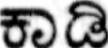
ಕಾಡಿ
